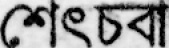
শেৎচবা
